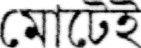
মোটেই
